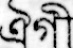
ঐগী
